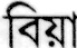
বিয়া
